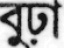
বুঢ়া
